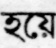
হয়ে
